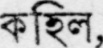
কহিল,
